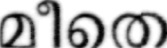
മീതെ
